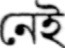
নেই
